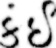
કંઈ
